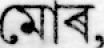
মোৰ,
